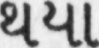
થયા
